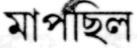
মাপছিল
